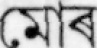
মোৰ
